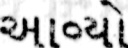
આવ્યો
